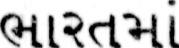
ભારતમાં
